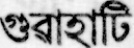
গুৱাহাটি
